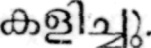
കളിച്ചു.
